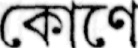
কোণে
